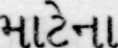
માટેના
